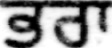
ਭਰਾ
